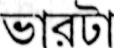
ভারটা
